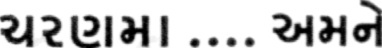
ચરણમા....અમને
